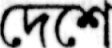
দেশে
